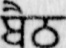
ਬੈਠ
